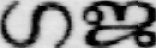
ഗജ
